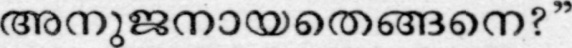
അനുജനായതെങ്ങനെ?"
